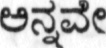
ಅನ್ನವೇ
